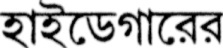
হাইডেগারের
